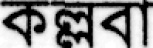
কল্লবা
